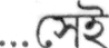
...সেই
